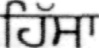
ਹਿੱਸਾ
